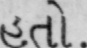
હતો.
